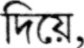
দিয়ে,
